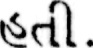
હતી.
